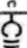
ਨੂੰ
